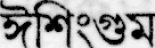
ঈশিংগুম
